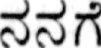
ನನಗೆ
